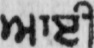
ਆਈ
